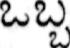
ಒಬ್ಬ
